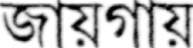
জায়গায়
